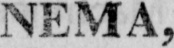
NEMA,
